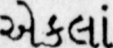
એકલાં
